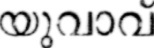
യുവാവ്
